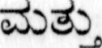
ಮತ್ತು
